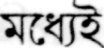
মধ্যেই
